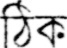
ঠিক
